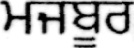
ਮਜਬੂਰ
